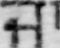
ਜਾ
